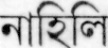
নাহিলি
